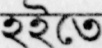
হইতে
